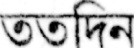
ততদিন
